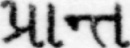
પ્રાન્ત
